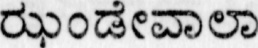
ಝಂಡೇವಾಲಾ
